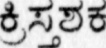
ಕ್ರಿಸ್ತಶಕ
